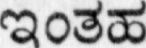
ಇಂತಹ
